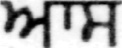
ਆਸ
